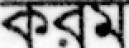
করম
